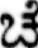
ಚೆ
